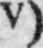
v)
